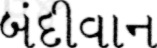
બંદીવાન
